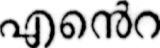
എന്റെ
